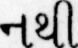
નથી
